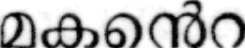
മകന്റെ
